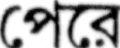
পেরে
